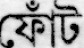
ফোঁট
